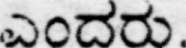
ಎಂದರು.
